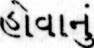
હોવાનું
